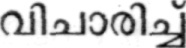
വിചാരിച്ച്
